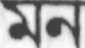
মন
